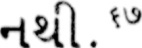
નથી.૬૭
